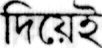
দিয়েই
